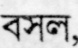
বসল,
